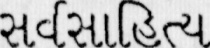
સર્વસાહિત્ય
